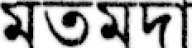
মতমদা
